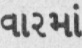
વારમાં
